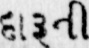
દારૂની
